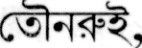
তৌনরুই,
